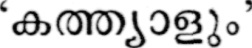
‘കത്ത്യാളും'
